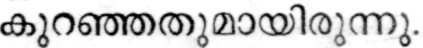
കുറഞ്ഞതുമായിരുന്നു.
